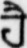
ਹੈ
